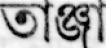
তাঞ্জা
